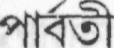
পার্বতী
